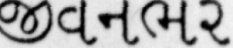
જીવનભર
